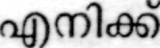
എനിക്ക്
